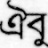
ঐবু
